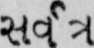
સર્વત્ર
